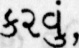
કરવું,
